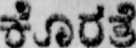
ಕೊರತೆ
